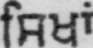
ਸਿਖਾਂ
